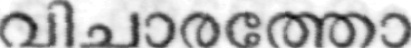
വിചാരത്തോ
